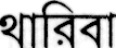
থারিবা
